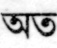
অত
